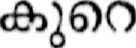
കുറെ
